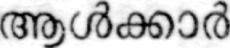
ആള്‍ക്കാര്‍
